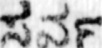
ಸರ್ವ
